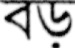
বড়
